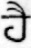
ਹੈ
